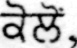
ਕੋਲੋਂ,
